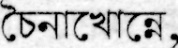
চৈনাখোন্নে,
